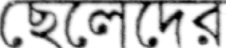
ছেলেদের
